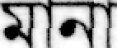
মানা
